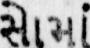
સોમાં
